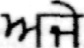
ਅਜੇ
